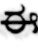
ಈ
